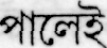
পালেই
